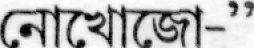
নোখোজো-"
